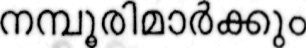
നമ്പൂരിമാര്‍ക്കും
